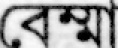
বেম্মা
